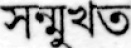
সন্মুখত
